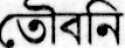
তৌবনি
